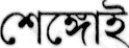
শেঙ্গোই
